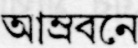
আম্রবনে
